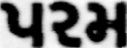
પરમ
